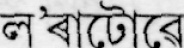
ল'ৰাটোৱে
